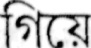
গিয়ে
